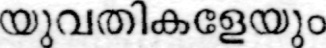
യുവതികളേയും
